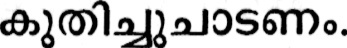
കുതിച്ചുചാടണം.
